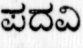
ಪದವಿ
